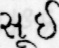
સૂઈ
